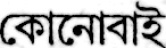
কোনোবাই
